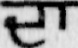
ਦਾ
